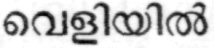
വെളിയില്‍
